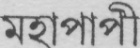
মহাপাপী
